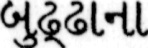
બુઢ્ઢાના
